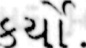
કર્યો.
